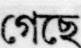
গেছে
